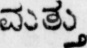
ಮತ್ತು
